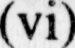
(vi)
